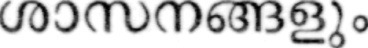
ശാസനങ്ങളും
